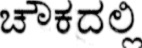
ಚೌಕದಲ್ಲಿ
